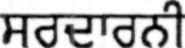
ਸਰਦਾਰਨੀ
